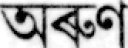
অৰুণ
